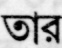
তার
